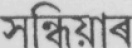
সন্ধিয়াৰ
